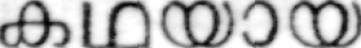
കഥയായ
